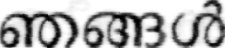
ഞങ്ങള്‍
